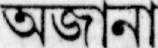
অজানা
